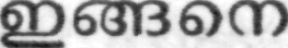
ഇങ്ങനെ
